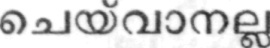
ചെയ്വാനല്ല
